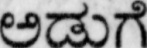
ಅಡುಗೆ
